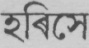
হৰিসে
